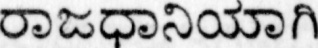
ರಾಜಧಾನಿಯಾಗಿ
